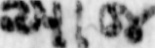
આજ
